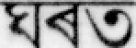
ঘৰত
